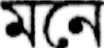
মনে
